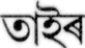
তাইৰ
